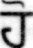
ਹੋ
